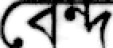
বেন্দ
